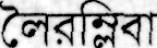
লৈরম্লিবা
